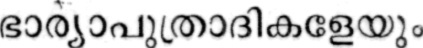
ഭാര്യാപുത്രാദികളേയും
